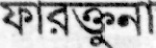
ফারক্তুনা
